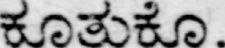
ಕೂತುಕೊ.
